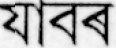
যাবৰ
